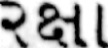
રક્ષા
